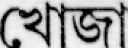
খোজা
